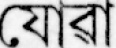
যোৱা
